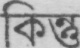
কিন্তু
